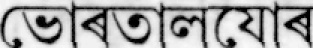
ভোৰতালযোৰ
